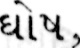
ઘોષ,
